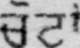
ਚੋਟਾਂ
